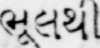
ભૂલથી
